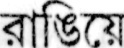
রাঙিয়ে
